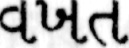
વખત
